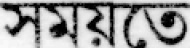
সময়তে
